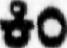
ಕಿಂ
